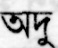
অদু
